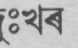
দুঃখৰ
